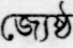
জ্যেষ্ঠ
